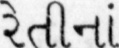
રેતીનાં
